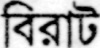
বিরাট
